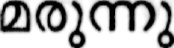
മരുന്നു
